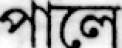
পালে
